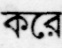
করে
